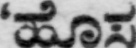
‘ಹೊಸ
